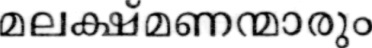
മലക്ഷ്മണന്മാരും
